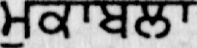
ਮੁਕਾਬਲਾ
